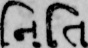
નિતિ
